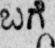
ಬಗ್ಗೆ
